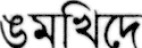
ঙমখিদে
